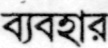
ব্যবহার
